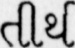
તીર્થ
